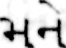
મને
